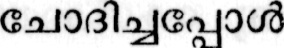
ചോദിച്ചപ്പോള്‍
